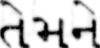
તેમને
